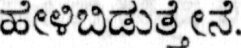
ಹೇಳಿಬಿಡುತ್ತೇನೆ.
